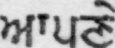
ਆਪਣੇ
